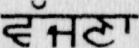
ਵੱਜਣਾ
